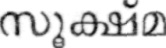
സൂക്ഷ്മ
